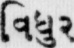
વિધુર
